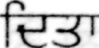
ਦਿਤਾ
